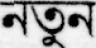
নতুন
